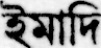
ইমাদি
